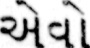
એવો
